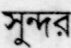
সুন্দর
